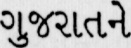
ગુજરાતને
